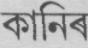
কানিৰ
